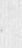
છે
